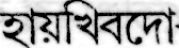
হায়খিবদো
